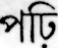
পঢ়ি
